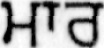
ਮਾਰ
